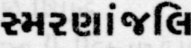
સ્મરણાંજલિ
